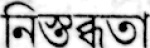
নিস্তব্ধতা
